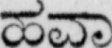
ಹವಾ
